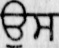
ਉਸ
